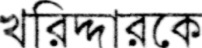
খরিদ্দারকে
